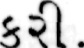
કરી.
